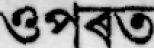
ওপৰত
